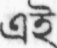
এই
